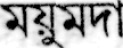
ময়ুমদা
